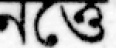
নত্তে
